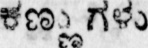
ಕಣ್ಣುಗಳು
